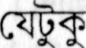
যেটুকু
